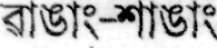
ৱাঙাং-শাঙাং
